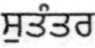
ਸੁਤੰਤਰ
